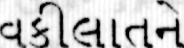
વકીલાતને
